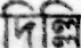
দিল্লি
